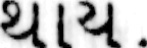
થાય.
